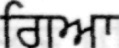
ਗਿਆ
